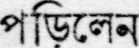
পড়িলেন
